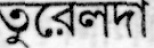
তুরেলদা
